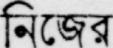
নিজের
